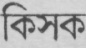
কিসক
